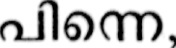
പിന്നെ,
